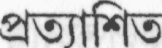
প্রত্যাশিত
